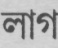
লাগ
